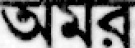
অমর
